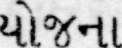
યોજના
